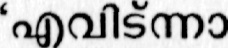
‘എവിട്ന്നാ
